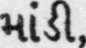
માંડી,
